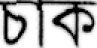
চাক
